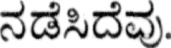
ನಡೆಸಿದೆವು.
